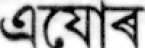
এযোৰ
